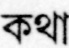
কথা
